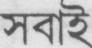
সবাই
